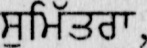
ਸੁਮਿੱਤਰਾ,
